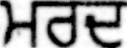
ਮਰਦ
